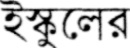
ইস্কুলের
